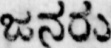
ಜನರು
